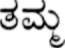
ತಮ್ಮ
